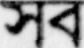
সব
